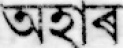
অহাৰ
